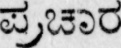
ಪ್ರಚಾರ
